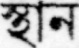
স্থান
